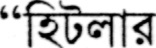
“হিটলার
